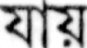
যায়
